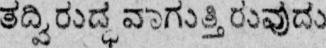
ತದ್ವಿರುದ್ಧವಾಗುತ್ತಿರುವುದು
